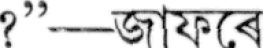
?"-জাফৰে
